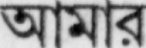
আমার
